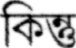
কিন্তু
